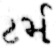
ટર્મ
